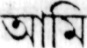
আমি
